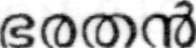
ഭരതന്‍
